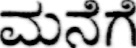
ಮನೆಗೆ
